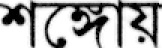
শঙ্গোয়
